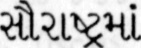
સૌરાષ્ટ્રમાં
